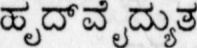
ಹೃದ್‌ವೈದ್ಯುತ
